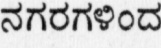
ನಗರಗಳಿಂದ
